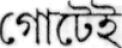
গোটেই
